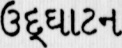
ઉદઘાટન
